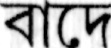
বাদে
